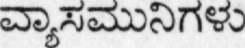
ವ್ಯಾಸಮುನಿಗಳು
